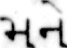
મને
